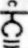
ਨੂੰ
